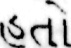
હતો
